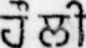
ਹੌਲੀ
